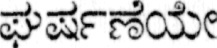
ಘರ್ಷಣೆಯೇ
